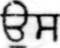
ਉਸ
